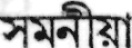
সমনীয়া
